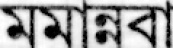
মমান্নবা
